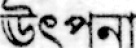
ঊৎপনা
